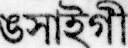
ঙসাইগী
